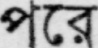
পরে
